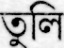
তুলি
